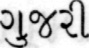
ગુજરી
